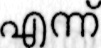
എന്ന്
